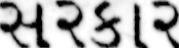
સરકાર
